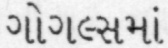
ગોગલ્સમાં
